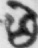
છે
